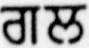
ਗਲ
